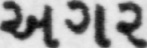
અગર
